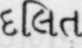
દલિત
